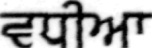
ਵਧੀਆ
